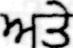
ਅਤੇ
